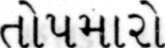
તોપમારો
